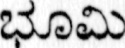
ಭೂಮಿ
